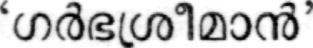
‘ഗര്‍ഭശ്രീമാന്‍’
